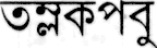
তম্লকপবু
